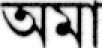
অমা
